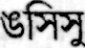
ঙসিসু
